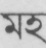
মহ
